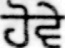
ਹੋਵੇ
